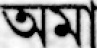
অমা
